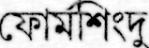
ফোর্মশিংদু
